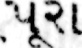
પૂરા
